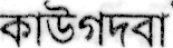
কাউগদবা
